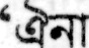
‘ঐনা
